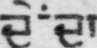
ਦੇਂਦਾ
